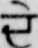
ਦੇ
